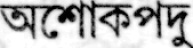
অশোকপদু
